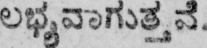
ಲಭ್ಯವಾಗುತ್ತವೆ.
